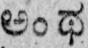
ಅಂಥ
